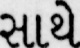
સાથે
